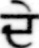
ਦੇ
